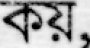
কয়,
